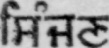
ਸਿੰਜਣ
